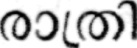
രാത്രി
